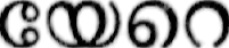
യേറെ
